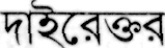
দাইরেক্তর
